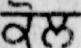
ਕੋਲ
